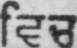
ਵਿਚ
